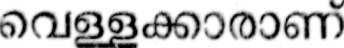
വെള്ളക്കാരാണ്
